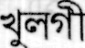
খুলগী
